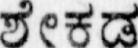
ಶೇಕಡ
